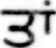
ਤਾਂ
